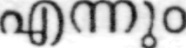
എന്നും
